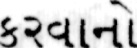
કરવાનો
